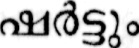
ഷര്‍ട്ടും
